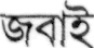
জবাই
